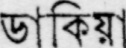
ডাকিয়া
